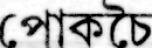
পোকচৈ
